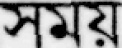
সময়
